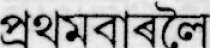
প্রথমবাৰলৈ
